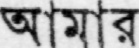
আমার
